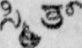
ಸ್ಮಿತ್
